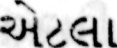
એટલા
